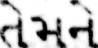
તેમને
